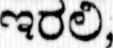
ಇರಲಿ,
